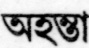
অহন্তা
